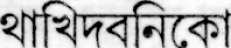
থাখিদবনিকো
